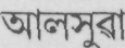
আলসুৱা
